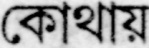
কোথায়
